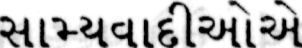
સામ્યવાદીઓએ
